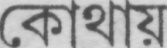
কোথায়
